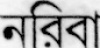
নরিবা
